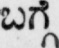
ಬಗ್ಗೆ
